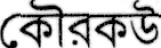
কৌরকউ
